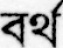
বর্থ
